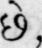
છે,
